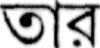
তার
